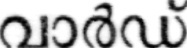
വാര്‍ഡ്
